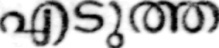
എടുത്ത
